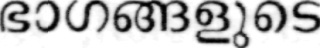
ഭാഗങ്ങളുടെ
